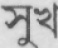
সুখ
